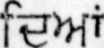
ਦਿਆਂ
